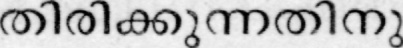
തിരിക്കുന്നതിനു
